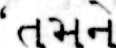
'તમને
